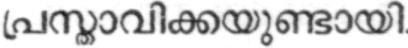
പ്രസ്താവിക്കയുണ്ടായി.
